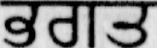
ਭਗਤ
